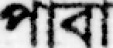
পাবা
